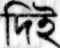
দিই
